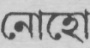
নোহো
